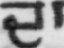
ਦਾ
